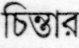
চিন্তার
